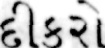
દીકરો
